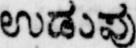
ಉಡುಪು
